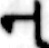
ન
